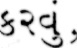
કરવું,
